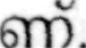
ണ്
